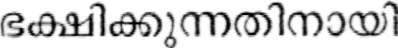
ഭക്ഷിക്കുന്നതിനായി
